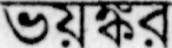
ভয়ঙ্কর
